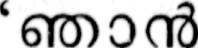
‘ഞാന്‍
